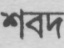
শবদ
